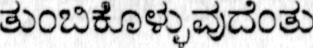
ತುಂಬಿಕೊಳ್ಳುವುದೆಂತು
